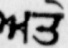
ਅਤੇ
